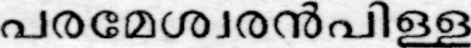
പരമേശ്വരന്‍പിള്ള
